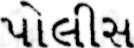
પોલીસ
